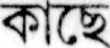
কাছে
